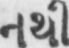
નથી
